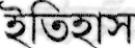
ইতিহাস
